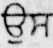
ਉਸ
